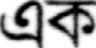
এক
